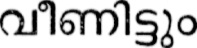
വീണിട്ടും
